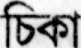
চিকা
